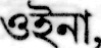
ওইনা,
